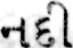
નદી
